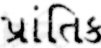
પ્રાંતિક
